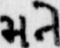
મને
